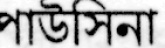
পাউসিনা
